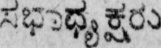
ಸಭಾಧ್ಯಕ್ಷರು
